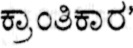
ಕ್ರಾಂತಿಕಾರ'
